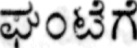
ಘಂಟೆಗೆ
